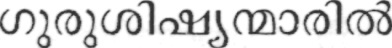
ഗുരുശിഷ്യന്മാരില്‍
